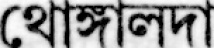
থোঙ্গালদা
